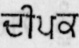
ਦੀਪਕ
